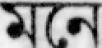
মনে
